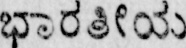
ಭಾರತೀಯ
